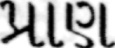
પ્રાણ
